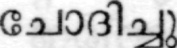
ചോദിച്ചു
